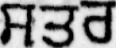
ਸਤਰ
